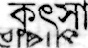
কুৎসা
